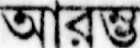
আরম্ভ
